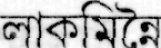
লাকমিন্নৈ
